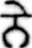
ਨੇ
